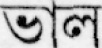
ভাল
